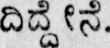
ದಿದ್ದೇನೆ.
